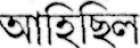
আহিছিল
